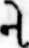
ને
